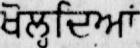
ਖੋਲ੍ਹਦਿਆਂ
